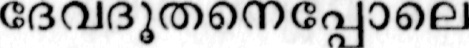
ദേവദൂതനെപ്പോലെ
